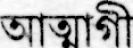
আত্মাগী
